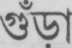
গুঁড়া
